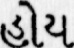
હોય
